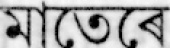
মাতেৰে
